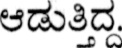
ಆಡುತ್ತಿದ್ದ.
